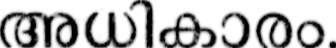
അധികാരം.
